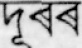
দূৰৰ
